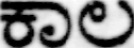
ಕಾಲ
